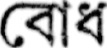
বোধ
